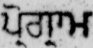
ਪ੍ਰੋਗ੍ਰਾਮ
